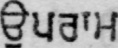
ਉਪਰਾਮ
